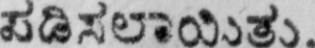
ಪಡಿಸಲಾಯಿತು.
